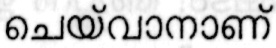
ചെയ്വാനാണ്
